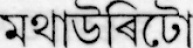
মথাউৰিটো
